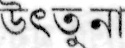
উৎতুনা
